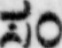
ಸಂ
